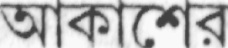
আকাশের
